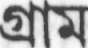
গ্রাম
